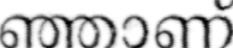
ഞ്ഞാണ്
